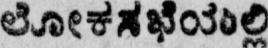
ಲೋಕಸಭೆಯಲ್ಲಿ
